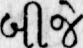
બીજે
